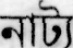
নাট্য
